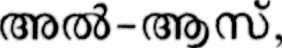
അല്‍-ആസ്,
